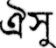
ঐসু
